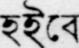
হইবে
